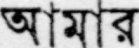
আমার
